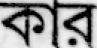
কার
